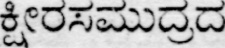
ಕ್ಷೀರಸಮುದ್ರದ
